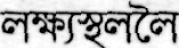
লক্ষ্যস্থললৈ
